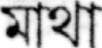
মাথা
